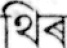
থিৰ
